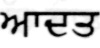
ਆਦਤ
